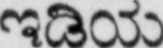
ಇಡಿಯ
